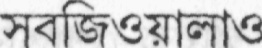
সবজিওয়ালাও
